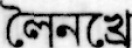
লৈনখ্রে
